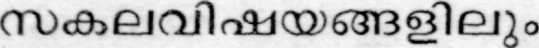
സകലവിഷയങ്ങളിലും
